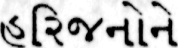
હરિજનોને
